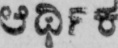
ಆರ್ಥಿಕ
